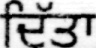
ਦਿੱਤਾ
